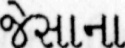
જેસાના
